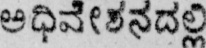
ಅಧಿವೇಶನದಲ್ಲಿ
